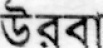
উরবা
